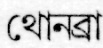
থোনব্রা
